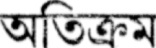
অতিক্রম
